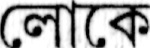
লোকে
